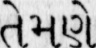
તેમણે
